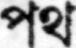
পথ
